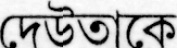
দেউতাকে
